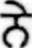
ਨੇ
